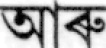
আৰু
